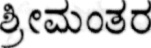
ಶ್ರೀಮಂತರ
